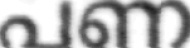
പണ
